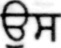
ਉਸ
